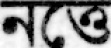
নত্তে
